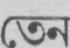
তেন
